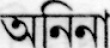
অনিনা
